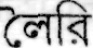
লৈরি
